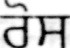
ਰੋਸ
